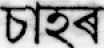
চাহৰ
